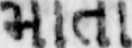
માતા
